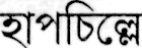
হাপচিল্লে
